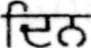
ਦਿਨ
